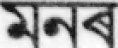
মনৰ
